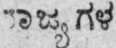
ರಾಜ್ಯಗಳ
